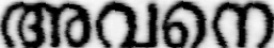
അവനെ
